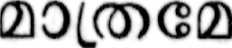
മാത്രമേ
